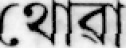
থোৱা
